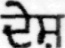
ਦੇਸ਼
